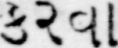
કરવા
